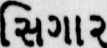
સિગાર
